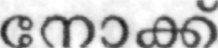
നോക്ക്
